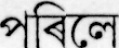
পৰিলে
